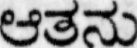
ಆತನು
